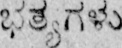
ಭತ್ಯಗಳು
